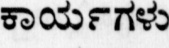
ಕಾರ್ಯಗಳು
